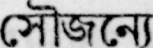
সৌজন্যে
